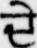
ਦੇ
